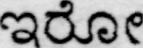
ಇರೋ
